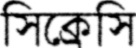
সিক্রেসি
